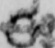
ಈ
